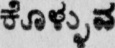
ಕೊಳ್ಳುವ
